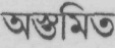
অস্তমিত
